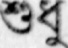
শুধু
